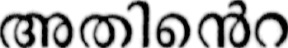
അതിന്റെ
